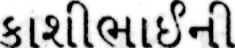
કાશીભાઈની
